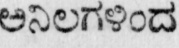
ಅನಿಲಗಳಿಂದ
